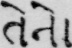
તેનો
